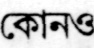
কোনও
